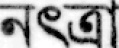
নৎত্রা
